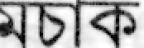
মচাক
